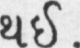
થઈ.
